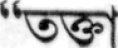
"তক্তা
